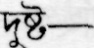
দুষ্ট-
